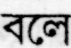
বলে
